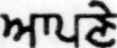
ਆਪਣੇ
